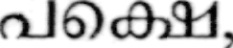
പക്ഷെ,
